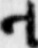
ન
